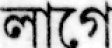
লাগে
